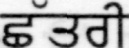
ਛੱਤਰੀ
